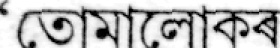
'তোমালোকৰ
